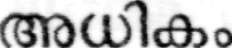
അധികം
